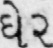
ઘેર
